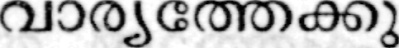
വാര്യത്തേക്കു
